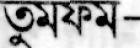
তুমফম-
